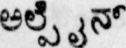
ಅಲ್ಪೈನ್
